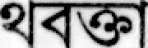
থবক্তা
